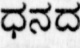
ಧನದ
